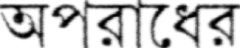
অপরাধের
